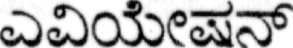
ಎವಿಯೇಷನ್
